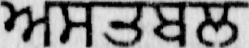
ਅਸਤਬਲ
